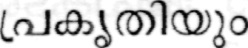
പ്രകൃതിയും
